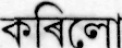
কৰিলো
